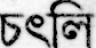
চৎলি
